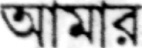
আমার
